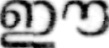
ഈ
